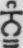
ਨੂੰ
